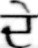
ਦੇ
